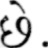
છે.
